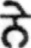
ਨੇ
